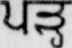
ਪੜ੍ਹ
